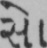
સો
